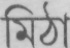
মিঠা
